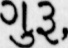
ગુરૂ,
